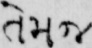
તેમજ
